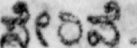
ಸೇರಿವೆ.
